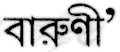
বারুণী’
